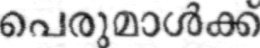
പെരുമാള്‍ക്ക്
